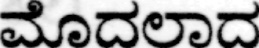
ಮೊದಲಾದ
